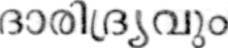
ദാരിദ്യ്രവും
